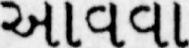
આવવા
